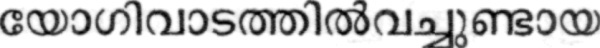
യോഗിവാടത്തില്‍വച്ചുണ്ടായ
